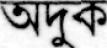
অদুক
